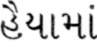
હૈયામાં
